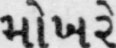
મોખરે
